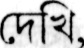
দেখি,
